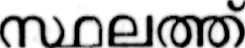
സ്ഥലത്ത്
